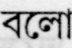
বলো
